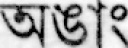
অঙাং
